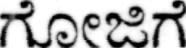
ಗೋಜಿಗೆ
